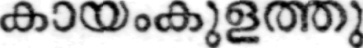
കായംകുളത്തു
